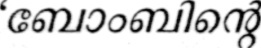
‘ബോംബിന്റെ
